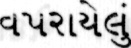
વપરાયેલું
